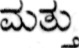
ಮತ್ತು
